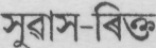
সুৱাস-ৰিক্ত
